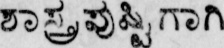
ಶಾಸ್ತ್ರಪುಷ್ಟಿಗಾಗಿ
